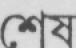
শেষ
